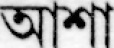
আশা
